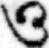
ও
